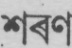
শৰণ
